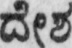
ದೇಶ
